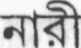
নারী
